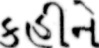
કહીને
